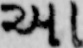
આ
